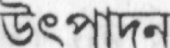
উৎপাদন
